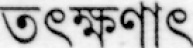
তৎক্ষণাৎ
